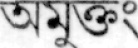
অমুক্তং
